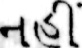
નહીં
